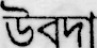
উবদা
